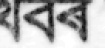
খবৰ
